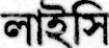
লাইসি
